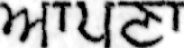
ਆਪਣਾ
